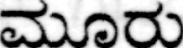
ಮೂರು
